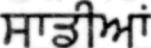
ਸਾਡੀਆਂ
